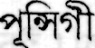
পূন্সিগী
